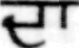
ਦਾ
